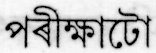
পৰীক্ষাটো
